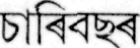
চাৰিবছৰ
